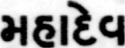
મહાદેવ
